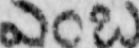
ಎಂಬ
